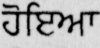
ਹੋਇਆ
